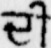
ਦੀ
